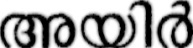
അയിര്‍
